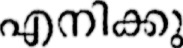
എനിക്കു
